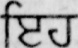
ਇਹ
